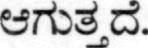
ಆಗುತ್ತದೆ.
